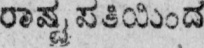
ರಾಷ್ಟ್ರಪತಿಯಿಂದ
